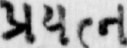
પ્રયત્ન
